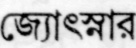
জ্যোত্স্নার
